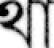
থা
